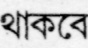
থাকবে
